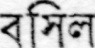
বসিল
